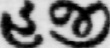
હજી
